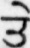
ਤੇ
